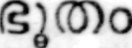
ഭൂതം
